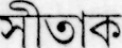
সীতাক
